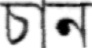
চান
